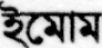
ইমোম
